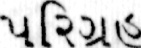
પરિગ્રહ
